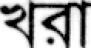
খরা
